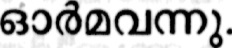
ഓര്‍മവന്നു.
